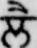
ਲੈ
